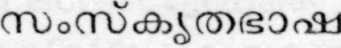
സംസ്കൃതഭാഷ
